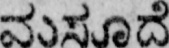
ಮಸೂದೆ
